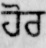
ਹੋਰ
